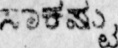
ಸಾಕಷ್ಟು
